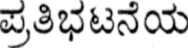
ಪ್ರತಿಭಟನೆಯ
